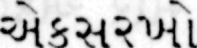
એકસરખો
